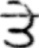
ਤੇ
